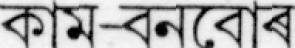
কাম-বনবোৰ
